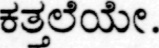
ಕತ್ತಲೆಯೇ.
